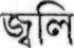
জ্বলি
